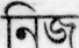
নিজ
